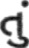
તું
